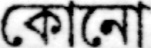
কোনো
